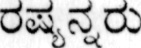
ರಷ್ಯನ್ನರು
